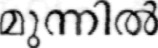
മുന്നില്‍
